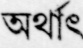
অর্থাত্
